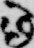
છે
